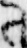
તે
